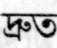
দ্রুত
